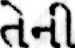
તેની
